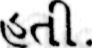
હતી.
